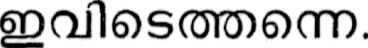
ഇവിടെത്തന്നെ.
